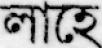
লাহে
